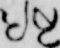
ઈષ્ટ
